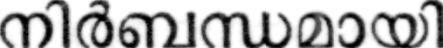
നിര്‍ബന്ധമായി
